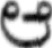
ಆ
